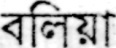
বলিয়া
